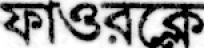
ফাওরক্লে
